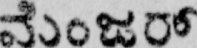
ಮೆಂಜರ್
